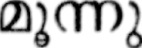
മൂന്നു
